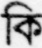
কি
